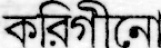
করিগীনো
